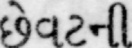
છેવટની
